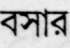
বসার
